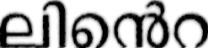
ലിന്റെ
